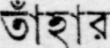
তাঁহার
